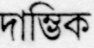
দাম্ভিক
